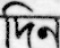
দিন
